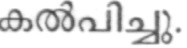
കല്‍പിച്ചു.
